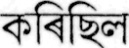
কৰিছিল
